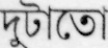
দুটাতো
